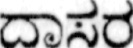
ದಾಸರ
